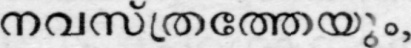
നവസ്ത്രത്തേയും,
